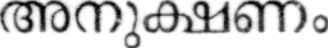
അനുക്ഷണം
